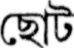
ছোট
